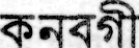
কনবগী
